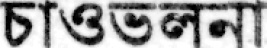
চাওভলনা
